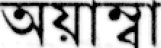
অয়াম্বা
